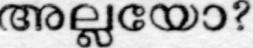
അല്ലയോ?
